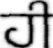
ਹੀ
